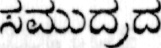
ಸಮುದ್ರದ
